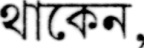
থাকেন,
